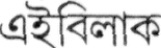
এইবিলাক
